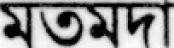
মতমদা
